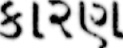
કારણ
